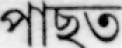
পাছত
